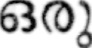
ഒരു
